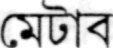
মেটাব
